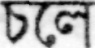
চলে
